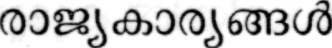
രാജ്യകാര്യങ്ങള്‍
